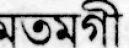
মতমগী
